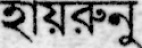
হায়রুনু
